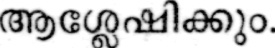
ആശ്ലേഷിക്കും.
